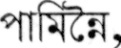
পামিন্নৈ,
